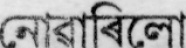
নোৱাৰিলো
